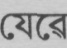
যেৱে
